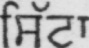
ਸਿੱਟਾ
